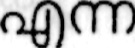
എന്ന
